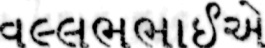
વલ્લભભાઈએ
